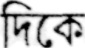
দিকে
